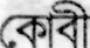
কোবী
